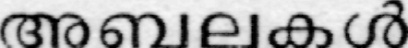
അബലകള്‍
